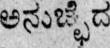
ಅನುಚ್ಛೆದ
